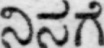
ನಿನಗೆ
